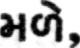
મળે,
